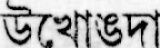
উখোঙদা
